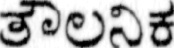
ತೌಲನಿಕ
